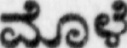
ಮೊಳೆ
